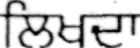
ਲਿਖਦਾ
